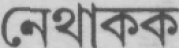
নেথাকক
